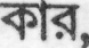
কার,
